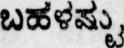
ಬಹಳಷ್ಟು
